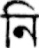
নি
